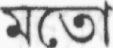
মতো
